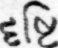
દષ્ટિ
